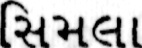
સિમલા
